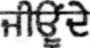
ਜੀਊਂਦੇ
